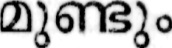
മുണ്ടും
